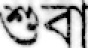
শুবা
